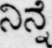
ನಿನ್ನೆ
